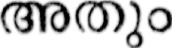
അതും
